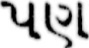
પણ
